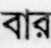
বার
